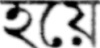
হয়ে
